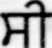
ਸੀ
